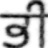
ਭੀ
